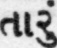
તારું
